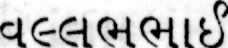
વલ્લભભાઈ
